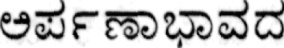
ಅರ್ಪಣಾಭಾವದ
